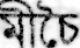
মীচৈ
